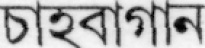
চাহবাগান
